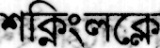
শক্নিংলক্লে
